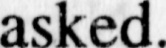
asked.
